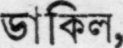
ডাকিল,
